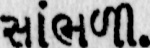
સાંભળી.
